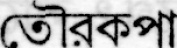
তৌরকপা
